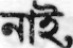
নাই,
